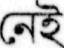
নেই
